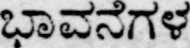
ಭಾವನೆಗಳ
